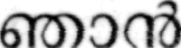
ഞാന്‍
